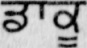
ਡਾਕੂ
